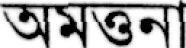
অমত্তনা
